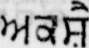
ਅਕਸ਼ੈ
